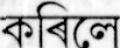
কৰিলে
